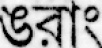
ঙরাং
